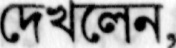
দেখলেন,
